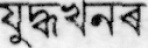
যুদ্ধখনৰ
